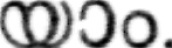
യാം.
